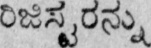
ರಿಜಿಸ್ಟರನ್ನು
